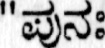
“ಪುನಃ
